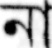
না
